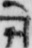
ਜੇ
